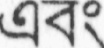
এবং
